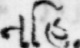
નહિ.
